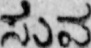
ಸುವ
